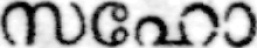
സഹോ
